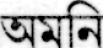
অমনি
